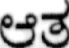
ಆತ
